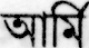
আর্মি
